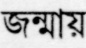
জন্মায়
